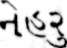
નેહરુ
